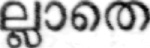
ല്ലാതെ
